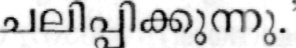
ചലിപ്പിക്കുന്നു.’
